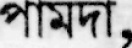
পামদা,
